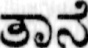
ತಾನೆ
